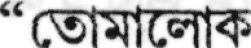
"তোমালোক
